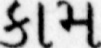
કામ
